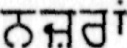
ਨਜ਼ਰਾਂ
